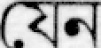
যেন
